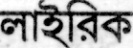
লাইরিক
